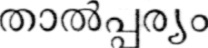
താല്‍പ്പര്യം
